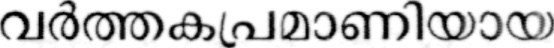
വര്‍ത്തകപ്രമാണിയായ
